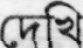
দেখি
